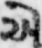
એ
